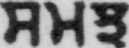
ਸਮਝ
